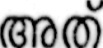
അത്
